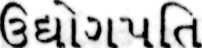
ઉદ્યોગપતિ
